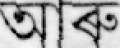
আৰু
